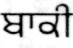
ਬਾਕੀ
